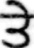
ਤੇ
